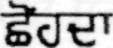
ਛੋਂਹਦਾ
